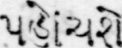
પહોંચશે
